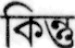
কিন্তু
